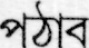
পঠাব
